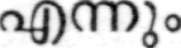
എന്നും
